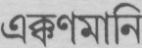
এক্কণমানি
